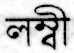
লম্বী
